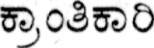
ಕ್ರಾಂತಿಕಾರಿ
